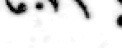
মরেং
